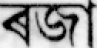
ৰজা
